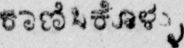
ಕಾಣಿಸಿಕೊಳ್ಳು
